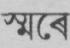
স্মৰে
